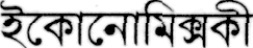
ইকোনোমিক্সকী
